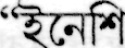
“ইনেশি
